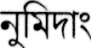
নুমিদাং
